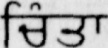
ਚਿੰਤਾ
